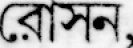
রোসন,
